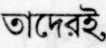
তাদেরই,
